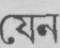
যেন
